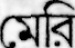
মেরি
